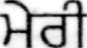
ਮੇਰੀ
